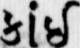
કાંઈ
